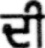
ਦੀ
